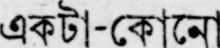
একটা-কোনো
